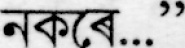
নকৰে..."
